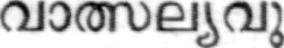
വാത്സല്യവു
